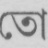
তো
